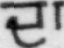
ਦਾ
